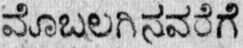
ಮೊಬಲಗಿನವರೆಗೆ
